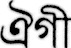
ঐগী
